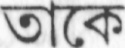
তাকে
